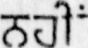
ਨਹੀਂ
